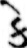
કે
